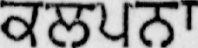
ਕਲਪਨਾ
